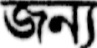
জন্য
